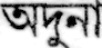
অদুনা
